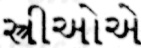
સ્ત્રીઓએ
